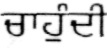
ਚਾਹੁੰਦੀ
